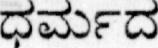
ಧರ್ಮದ
